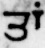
ਤਾਂ
